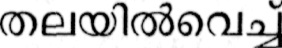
തലയില്‍വെച്ച്
